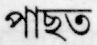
পাছত
